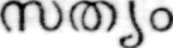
സത്യം
